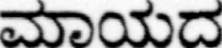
ಮಾಯದ
